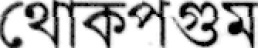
থোকপগুম
